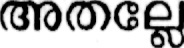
അതല്ലേ
